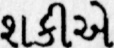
શકીએ
